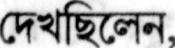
দেখছিলেন,
